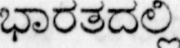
ಭಾರತದಲ್ಲಿ
